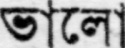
ভালো
